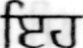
ਇਹ
